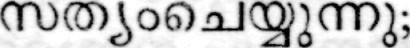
സത്യംചെയ്യുന്നു;
